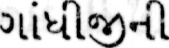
ગાંધીજીની
